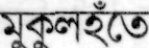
মুকুলহঁতে
